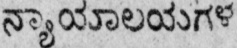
ನ್ಯಾಯಾಲಯಗಳ
